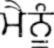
ਮੈਨੂੰ
